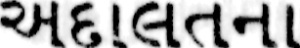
અદાલતના
